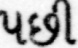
પછી
